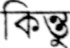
কিন্তু
